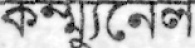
কম্ম্যুনেল
